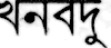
খনবদু
